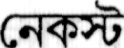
নেকস্ট
